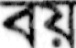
বয়
